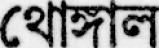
থোঙ্গাল
